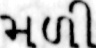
મળી
